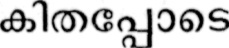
കിതപ്പോടെ
